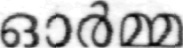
ഓര്‍മ്മ
